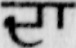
ਦਾ
